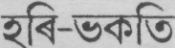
হৰি-ভকতি
